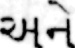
અને
